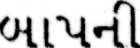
બાપની
